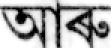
আৰু
